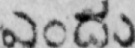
ಎಂದು
